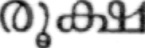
രൂക്ഷ
